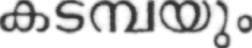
കടമ്പയും
